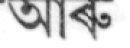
'আৰু
